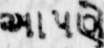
આપણે
